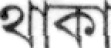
থাকা
